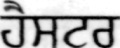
ਹੈਸਟਰ
